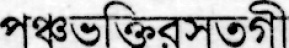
পঞ্চভক্তিরসতগী
